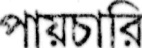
পায়চারি
